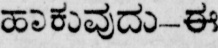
ಹಾಕುವುದು-ಈ
